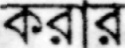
করার
